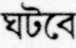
ঘটবে
